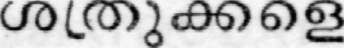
ശത്രുക്കളെ
